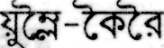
য়ুম্লৈ-কৈরৈ
